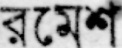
রমেশ
